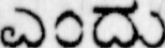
ಎಂದು
